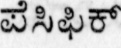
ಪೆಸಿಫಿಕ್
